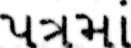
પત્રમાં
